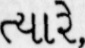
ત્યારે,
